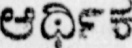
ಆರ್ಥಿಕ
